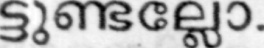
ട്ടുണ്ടല്ലോ.
